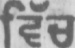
ਵਿੱਚ
